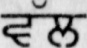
ਵੱਲ
